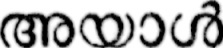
അയാള്‍
